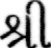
શ્રી
